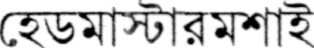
হেডমাস্টারমশাই
